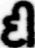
દી
